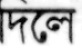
দিলে
